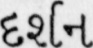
દર્શન
